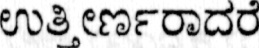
ಉತ್ತೀರ್ಣರಾದರೆ
